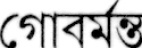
গোবর্মন্ত
